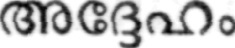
അദ്ദേഹം
